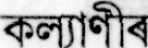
কল্যাণীৰ
